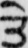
ਤੇ
